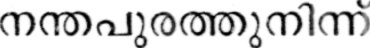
നന്തപുരത്തുനിന്ന്
